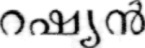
റഷ്യന്‍
